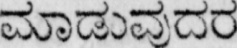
ಮಾಡುವುದರ
